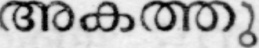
അകത്തു
